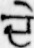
ਦੇ
